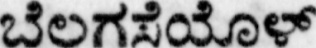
ಬೆಲಗಸೆಯೊಳ್
